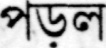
পড়ল
